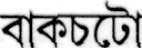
বাকচটো
